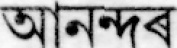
আনন্দৰ
